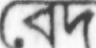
বেদ
